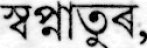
স্বপ্নাতুৰ,
